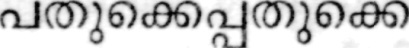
പതുക്കെപ്പതുക്കെ
